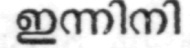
ഇന്നിനി
